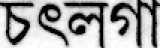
চৎলগা
